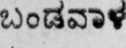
ಬಂಡವಾಳ
